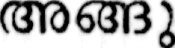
അങ്ങു
